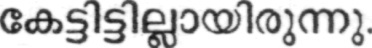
കേട്ടിട്ടില്ലായിരുന്നു.
